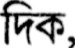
দিক,
